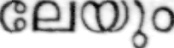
ലേയും
